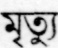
মৃত্যু
